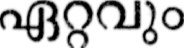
ഏറ്റവും
